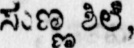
ಸುಣ್ಣಶಿಲೆ,
